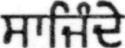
ਸਾਜਿੰਦੇ
